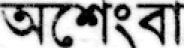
অশেংবা
